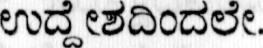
ಉದ್ದೇಶದಿಂದಲೇ.
